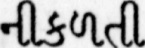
નીકળતી
